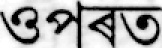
ওপৰত
